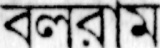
বলরাম
